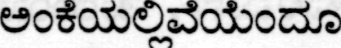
ಅಂಕೆಯಲ್ಲಿವೆಯೆಂದೂ
